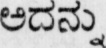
ಅದನ್ನು
